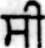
ਸੀ
